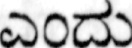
ಎಂದು
